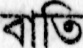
বাতি
